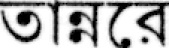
তান্নরে
